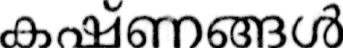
കഷ്ണങ്ങള്‍
